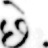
છે.
